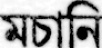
মচানি
